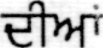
ਦੀਆਂ
